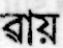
ৱায়
